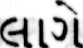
લાગે
